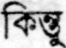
কিন্তু
